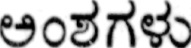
ಅಂಶಗಳು
